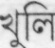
খুলি
